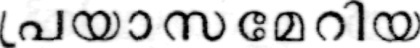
പ്രയാസമേറിയ
